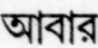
আবার
